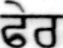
ਫੇਰ
